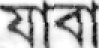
যাবা
